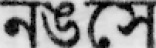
নঙসে
